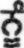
ਨੂੰ
